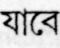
যাবে
